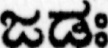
ಜಡಃ
